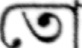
তো
